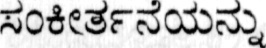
ಸಂಕೀರ್ತನೆಯನ್ನು
